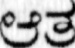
ಆತ
